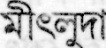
মীৎলুদা
